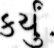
કર્યું.
